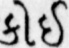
કોઈ
